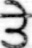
ਤੇ
